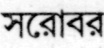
সরোবর
